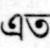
এত
